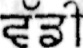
ਵੱਡੀ
